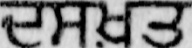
ਦਸਖ਼ਤ
